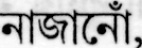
নাজানোঁ,
